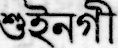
শুইনগী
